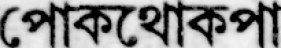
পোকথোকপা
